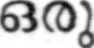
ഒരു
